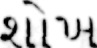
શોખ
